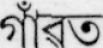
গাঁৱত
